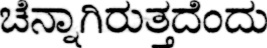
ಚೆನ್ನಾಗಿರುತ್ತದೆಂದು
